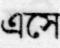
এসে
